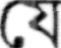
যে
